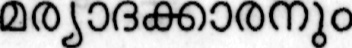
മര്യാദക്കാരനും
